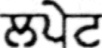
ਲਪੇਟ
